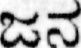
ಜನ
